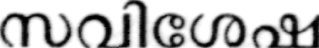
സവിശേഷ
